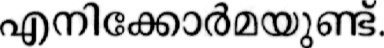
എനിക്കോര്‍മയുണ്ട്.
